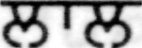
ਲਾਲ
